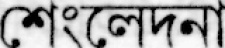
শেংলেদনা
